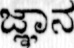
ಜ್ಞಾನ
